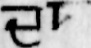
ਦਾ
